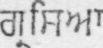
ਗ੍ਰਸਿਆ
